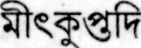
মীৎকুপ্তুদি
